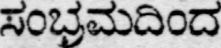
ಸಂಭ್ರಮದಿಂದ
